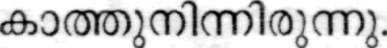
കാത്തുനിന്നിരുന്നു.
